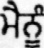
ਮੈਨੂੰ
